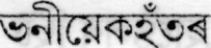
ভনীয়েকহঁতৰ
